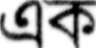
এক
